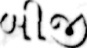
બીજી
